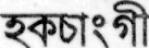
হকচাংগী
